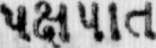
પક્ષપાત
